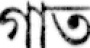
গাত
